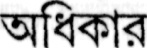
অধিকার
